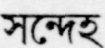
সন্দেহ
